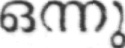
ഒന്നു
